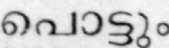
പൊട്ടും
